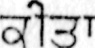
ਕੀਤਾ
